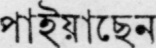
পাইয়াছেন
